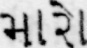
મારો
